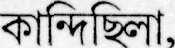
কান্দিছিলা,
